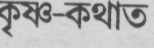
কৃষ্ণ-কথাত
